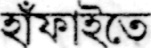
হাঁফাইতে
